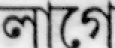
লাগে
